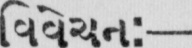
વિવેચનઃ-
